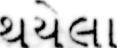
થયેલા
